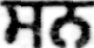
ਸਨ
